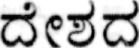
ದೇಶದ
